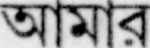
আমার
